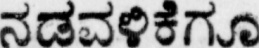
ನಡವಳಿಕೆಗೂ
